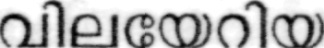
വിലയേറിയ
